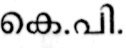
കെ.പി.
